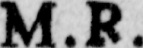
M.R.
